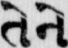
તેને
